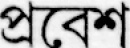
প্রবেশ
